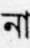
না
